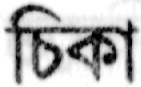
চিকা
